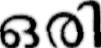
ഒരി
